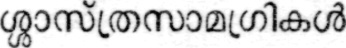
ശ്ശാസ്ത്രസാമഗ്രികള്‍
